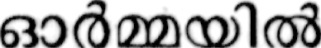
ഓര്‍മ്മയില്‍
